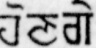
ਹੋਣਗੇ
